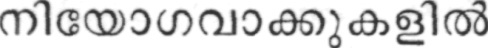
നിയോഗവാക്കുകളില്‍
